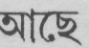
আছে
